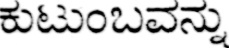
ಕುಟುಂಬವನ್ನು
